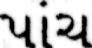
પાંચ
